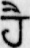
ਹੈ
